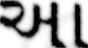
આ
